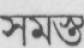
সমস্ত
